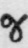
જ
